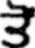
ਤੋਂ
